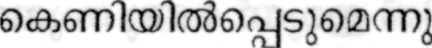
കെണിയില്‍പ്പെടുമെന്നു
